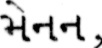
મેનન,
